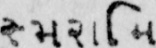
સ્મરામિ
